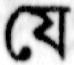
যে
